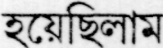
হয়েছিলাম
